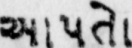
આપતો
